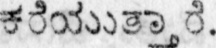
ಕರೆಯುತ್ತಾರೆ.
